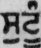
ਸੁਟੂੰ
